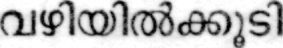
വഴിയില്‍ക്കൂടി
